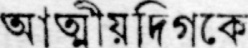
আত্মীয়দিগকে
